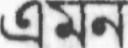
এমন
